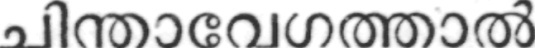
ചിന്താവേഗത്താല്‍
